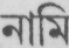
নামি
